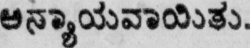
ಅನ್ಯಾಯವಾಯಿತು.
